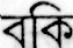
বকি
